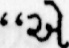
"એ
